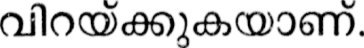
വിറയ്ക്കുകയാണ്.
